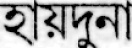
হায়দুনা
